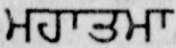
ਮਹਾਤਮਾ
